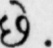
છે.
